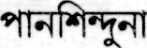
পানশিন্দুনা
